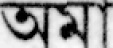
অমা
